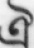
ঐ
